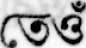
তেওঁ
